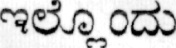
ಇಲ್ಲೊಂದು
